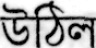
উঠিল
